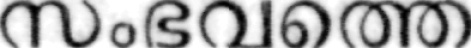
സംഭവത്തെ
